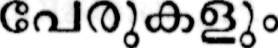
പേരുകളും
